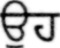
ਉਹ
